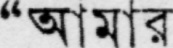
‘‘আমার
